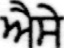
ਐਸੇ
